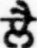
ਲੈ
